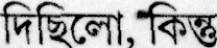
দিছিলো,কিন্তু
